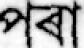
পৰা
